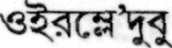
ওইরম্লে’দুবু
